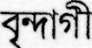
বৃন্দাগী
